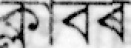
ক্লাবৰ
